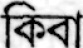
কিবা
